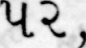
પર,
